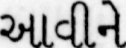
આવીને
